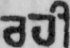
ਰਹੀ
